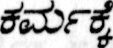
ಕರ್ಮಕ್ಕೆ
